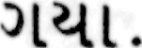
ગયા.
